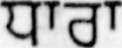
ਧਾਰਾ
